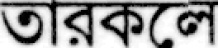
তারকলে
